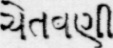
ચેતવણી
